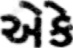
એકે
